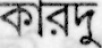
কারদু
